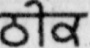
ਠੀਕ
